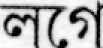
লগে
